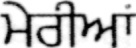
ਮੇਰੀਆਂ
